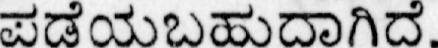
ಪಡೆಯಬಹುದಾಗಿದೆ.
